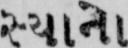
સ્યાને
